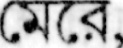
মেরে,
